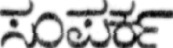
ಸಂಪರ್ಕ
